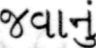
જવાનું
